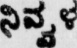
ನಿವ್ವಳ
